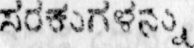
ಸರಕುಗಳನ್ನು
